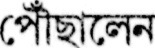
পৌঁছালেন
